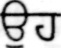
ਉਹ
